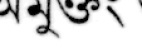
অমুক্তং
